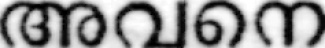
അവനെ
